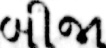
બીજા
